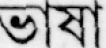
ভাষা
